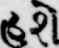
હશે
